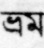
ভ্রম
